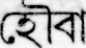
হৌবা
